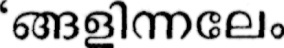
'ങ്ങളിന്നലേം
